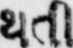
થતી
